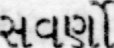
સવર્ણો
